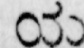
ಯ
